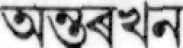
অন্তৰখন
